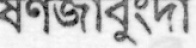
ষণজাবুংদা
